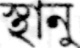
স্থানু
